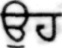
ਉਹ
